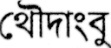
থৌদাংবু
